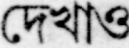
দেখাও
